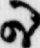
જે
